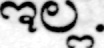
ಇಲ್ಲ.
